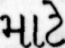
માટે
